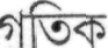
গতিক
